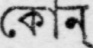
কোন্
